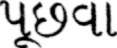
પૂછવા
